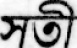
সতী
